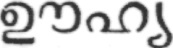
ഊഹ്യ
